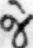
જે
